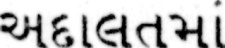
અદાલતમાં
